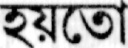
হয়তো
